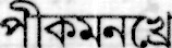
পীকমনখ্রে
